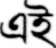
এই
